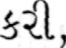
કરી,
